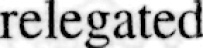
relegated
